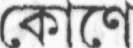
কোণে
